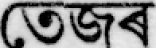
তেজৰ
